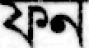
ফন
